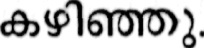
കഴിഞ്ഞു.
